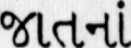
જાતનાં
